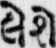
લેશે
